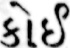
કોઈ
